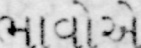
ભાવોએ
